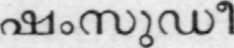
ഷംസുഡീ
